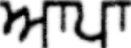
ਆਪਾ
